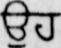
ਉਹ
